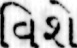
વિશે
